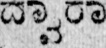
ದ್ವಾರಾ
